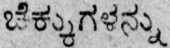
ಚೆಕ್ಕುಗಳನ್ನು
